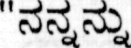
“ನನ್ನನ್ನು
